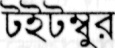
টইটম্বুর
